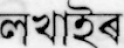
লখাইৰ
